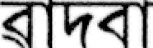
ৱাদবা
